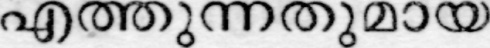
എത്തുന്നതുമായ
